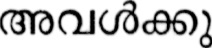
അവള്‍ക്കു
